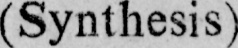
(Synthesis)
